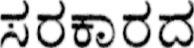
ಸರಕಾರದ
